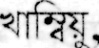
খাম্বিয়ু,
